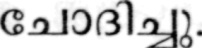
ചോദിച്ചു.
